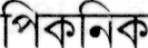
পিকনিক
